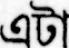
এটা
